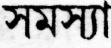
সমস্যা
